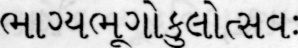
ભાગ્યભૂગોકુલોત્સવઃ
